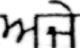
ਅਜੇ
